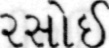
રસોઈ
